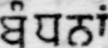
ਬੰਧਨਾਂ
